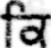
ਕਿ
